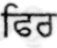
ਫਿਰ
